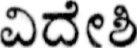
ವಿದೇಶಿ
